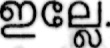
ഇല്ലേ.
